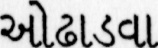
ઓઢાડવા
